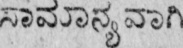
ಸಾಮಾನ್ಯವಾಗಿ
